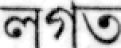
লগত
